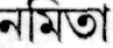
নমিতা
